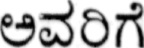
ಅವರಿಗೆ
